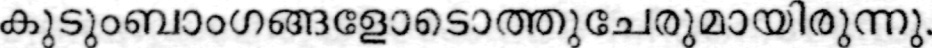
കുടുംബാംഗങ്ങളോടൊത്തുചേരുമായിരുന്നു.
